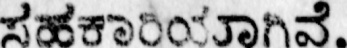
ಸಹಕಾರಿಯಾಗಿವೆ.
